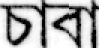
চাবা
